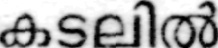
കടലില്‍
